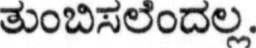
ತುಂಬಿಸಲೆಂದಲ್ಲ.
